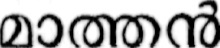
മാത്തന്‍
